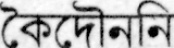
কৈদৌননি
